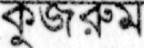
কুজরুম
